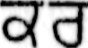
ਕਰ
